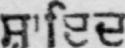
ਸ਼ਾਇਦ
